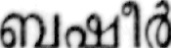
ബഷീര്‍
